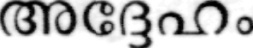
അദ്ദേഹം
